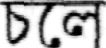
চলে
